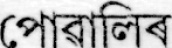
পোৱালিৰ
